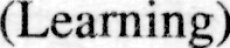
(Learnign)
